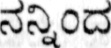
ನನ್ನಿಂದ
